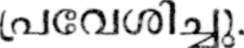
പ്രവേശിച്ചു.
